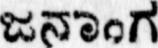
ಜನಾಂಗ
